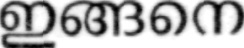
ഇങ്ങനെ
